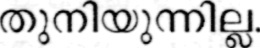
തുനിയുന്നില്ല.
